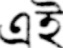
এই
